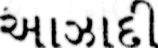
આઝાદી
